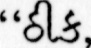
"ઠીક,
